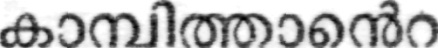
കാമ്പിത്താന്റെ
